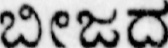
ಬೀಜದ
